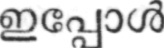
ഇപ്പോള്‍
